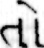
તો
